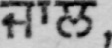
ਜਾਲ,
